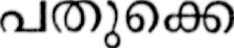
പതുക്കെ
